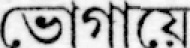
ভোগায়ে
